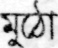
মুঠো
